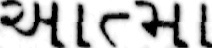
આત્મા
